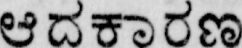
ಆದಕಾರಣ
